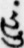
હું
